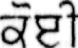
ਕੋਈ
